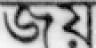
জয়
